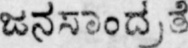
ಜನಸಾಂದ್ರತೆ
